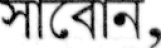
সাবোন,
